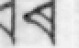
বৰ
